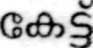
കേട്ട്
